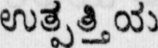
ಉತ್ಪತ್ತಿಯ
